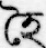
হৈ
